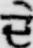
ਦੇ
